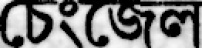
চেংজেল
